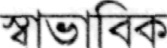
স্বাভাবিক
